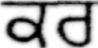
ਕਰ
